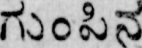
ಗುಂಪಿನ
